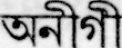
অনীগী
